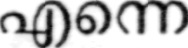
എന്നെ
